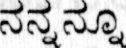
ನನ್ನನ್ನೂ
